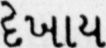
દેખાય
